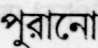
পুরানো
